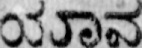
ಯಾವ
